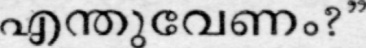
എന്തുവേണം?''”
